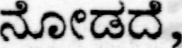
ನೋಡದೆ,
